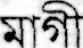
মাগী
